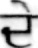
ਦੇ
